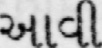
આવી
